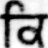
ਕਿ
